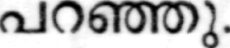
പറഞ്ഞു.
